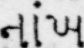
નાંખ
